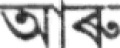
আৰু
